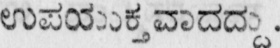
ಉಪಯುಕ್ತವಾದದ್ದು.
